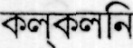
কল‌্কলনি
